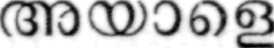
അയാളെ
